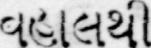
વહાલથી
